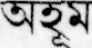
অহূম
